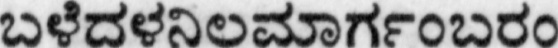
ಬಳೆದಳನಿಲಮಾರ್ಗಂಬರಂ
